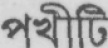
পখীটি
